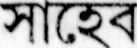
সাহেব
